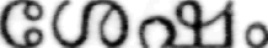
ശേഷം
